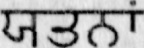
ਯਤਨਾਂ
